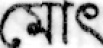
মোৎ
